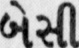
બેસી
